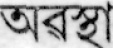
অৱস্থা
